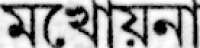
মখোয়না
